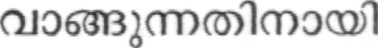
വാങ്ങുന്നതിനായി
